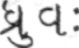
ધ્રુવઃ
